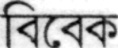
বিবেক
